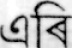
এৰি
